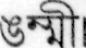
ঙম্মী।
